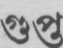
গুপ্ত
